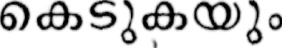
കെടുകയും
